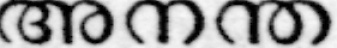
അനന്ത
